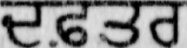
ਦਫ਼ਤਰ
